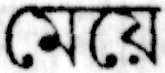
মেয়ে
